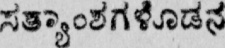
ಸತ್ಯಾಂಶಗಳೊಡನ
